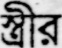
স্ত্রীর
